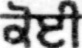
ਕੋਈ
